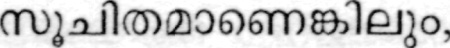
സൂചിതമാണെങ്കിലും,
